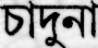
চাদুনা
